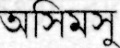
অসিমসু
